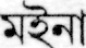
মইনা
